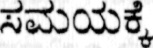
ಸಮಯಕ್ಕೆ
